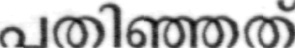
പതിഞ്ഞത്
